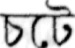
চটে
